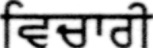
ਵਿਚਾਰੀ
